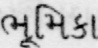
ભૂમિકા
